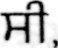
ਸੀ,
